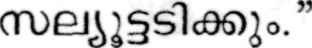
സല്യൂട്ടടിക്കും."
